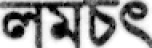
লমচৎ
